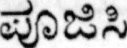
ಪೂಜಿಸಿ
